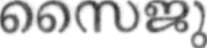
സൈജു
